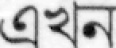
এখন
